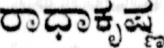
ರಾಧಾಕೃಷ್ಣ
